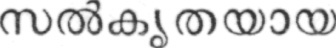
സല്‍കൃതയായ
